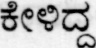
ಕೇಳಿದ್ದ
